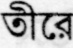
তীরে
